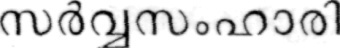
സര്‍വ്വസംഹാരി
